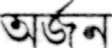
অর্জন
